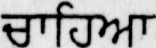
ਚਾਹਿਆ
